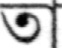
তা
